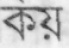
কিয়
